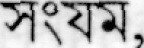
সংযম,
